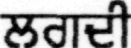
ਲਗਦੀ
